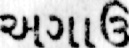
અગાઉ
